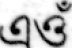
এওঁ
